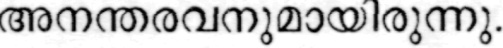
അനന്തരവനുമായിരുന്നു.
